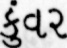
કુંવર
